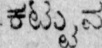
ಕಟ್ಟುವ
